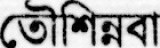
তৌশিন্নবা
